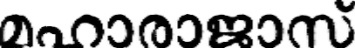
മഹാരാജാസ്
